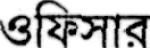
ওফিসার
